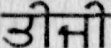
ਤੀਜੀ
